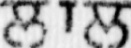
ਲਾਲ
